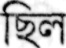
ছিল
